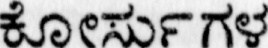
ಕೋರ್ಸುಗಳ
